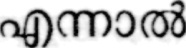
എന്നാല്‍
